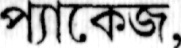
প্যাকেজ,
